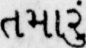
તમારું
